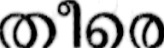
തീരെ
